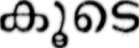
കൂടെ
